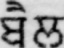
ਬੈਲ
